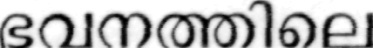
ഭവനത്തിലെ
